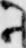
ને?
